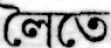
লৈতে
